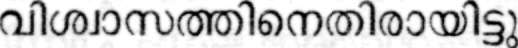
വിശ്വാസത്തിനെതിരായിട്ടു
